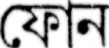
ফোন
